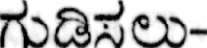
ಗುಡಿಸಲು-
